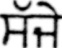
ਸੱਜੇ
